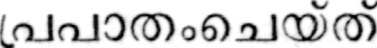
പ്രപാതംചെയ്ത്
